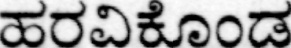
ಹರವಿಕೊಂಡ
